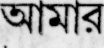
আমার
